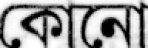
কোনো
